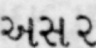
અસર
